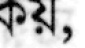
কয়,
